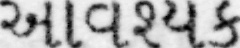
આવશ્યક
